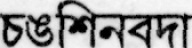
চঙশিনবদা
